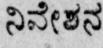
ನಿವೇಶನ
